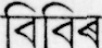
বিবিৰ
